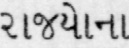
રાજ્યોના
